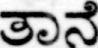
ತಾನೆ
